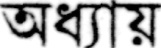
অধ্যায়
